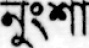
নুংশা
